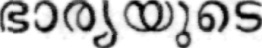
ഭാര്യയുടെ
